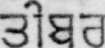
ਤੀਬਰ
